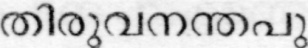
തിരുവനന്തപു
